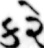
કરે
